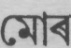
মোৰ
